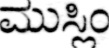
ಮುಸ್ಲಿಂ
